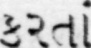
કરતાં
